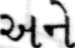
અને
